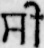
ਸੀ
